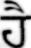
ਹੈ
